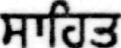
ਸਾਹਿਤ
